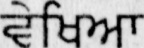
ਵੇਖਿਆ
